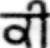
ਕੀ
